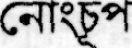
নোংচূপ
